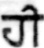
ਹੀ
